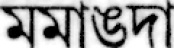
মমাঙদাল
